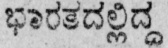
ಭಾರತದಲ್ಲಿದ್ದ
